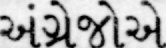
અંગ્રેજોએ
